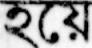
হয়ে
